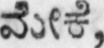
ಮೇಕೆ,
